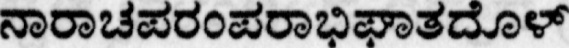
ನಾರಾಚಪರಂಪರಾಭಿಘಾತದೊಳ್
